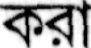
করা
